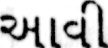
આવી
